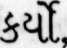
કર્યો,
